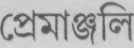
প্ৰেমাঞ্জলি
